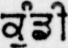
ਕੁੰਡੀ
